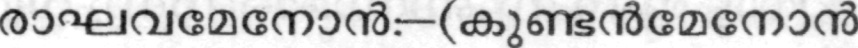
രാഘവമേനോന്‍:-കുണ്ടന്‍േനോന്‍
